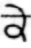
ਕੇ
